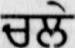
ਚਲੇ
